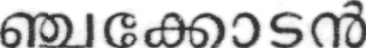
ഞ്ചക്കോടന്‍
